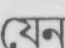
যেন
